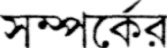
সম্পর্কের
